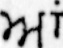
ਆਂ
